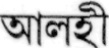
আলহী
